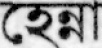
হেন্না
